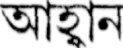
আহ্বান
